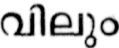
വിലും
